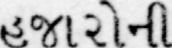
હજારોની
